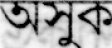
অসুক
